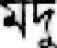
মদু
